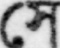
সে
